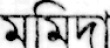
মমিদা
